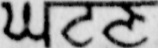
ਘਟਣ
